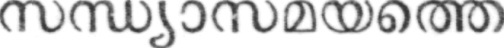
സന്ധ്യാസമയത്തെ
